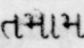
તમામ
